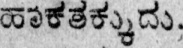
ಹಾಕತಕ್ಕುದು.
